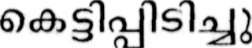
കെട്ടിപ്പിടിച്ചു
